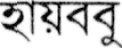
হায়ববু
